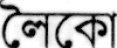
লৈকো
